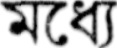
মধ্যে
